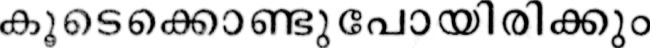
കൂടെക്കൊണ്ടുപോയിരിക്കും
